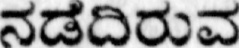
ನಡೆದಿರುವ
